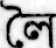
লৈ
